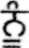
ਨੂੰ
